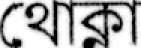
থোক্না
